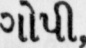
ગોપી,
